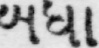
બધા
